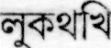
লুকথখি
